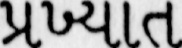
પ્રખ્યાત
